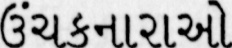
ઉંચકનારાઓ
